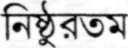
নিষ্ঠুরতম
